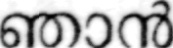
ഞാന്‍
